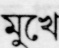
মুখে
